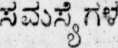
ಸಮಸ್ಯೆಗಳ
